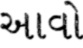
આવો
